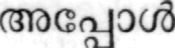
അപ്പോള്‍
